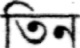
তিন
